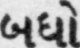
બધો
